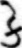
કે
